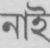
নাই
